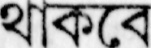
থাকবে
